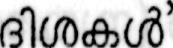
ദിശകള്‍'
